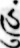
હું
